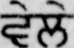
ਵੇਲੇ
